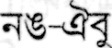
নঙ-ঐবু
